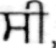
ਸੀ,
